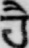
ਹੈ
